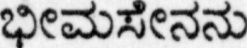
ಭೀಮಸೇನನು
